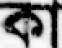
কা
